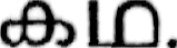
കഥ.
